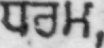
ਧਰਮ,
